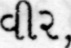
વીર,
